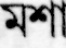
মশা
